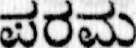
ಪರಮ
